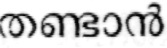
തണ്ടാന്‍
